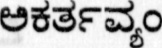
ಅಕರ್ತವ್ಯ೦
